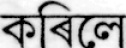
কৰিলে
